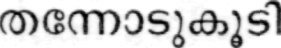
തന്നോടുകൂടി
